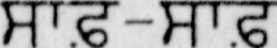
ਸਾਫ਼-ਸਾਫ਼
